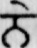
ਨੇ
